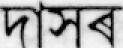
দাসৰ
